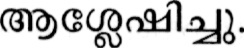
ആശ്ലേഷിച്ചു.
